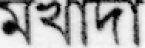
মখাদা
